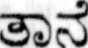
ತಾನೆ
